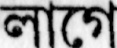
লাগে
